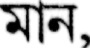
মান,
